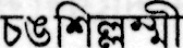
চঙশিল্লম্মী
